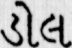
ડોલ
